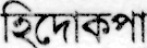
হিদোকপা
